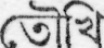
তৌখি
